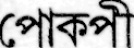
পোকপী
